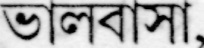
ভালবাসা,
